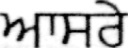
ਆਸਰੇ
